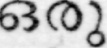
ഒരു
